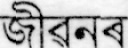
জীৱনৰ
